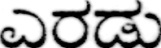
ಎರಡು
